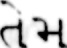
તેમ
